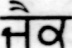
ਜੈਕ
